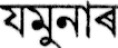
যমুনাৰ
